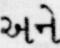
અને
